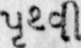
પૃથ્વી
